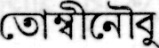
তোম্বীনৌবু
